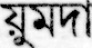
য়ুমদা
